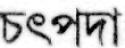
চৎপদা
